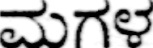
ಮಗಳ
